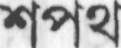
শপথ
